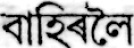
বাহিৰলৈ
